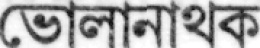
ভোলানাথক
